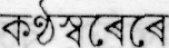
কণ্ঠস্বৰেৰে
